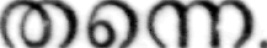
തന്നെ.
